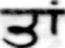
ਤਾਂ
